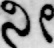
ನೀ
